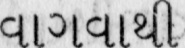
વાગવાથી
